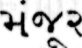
મંજૂર
